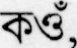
কওঁ,
